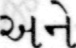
અને
